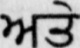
ਅਤੇ
